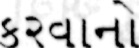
કરવાનો
